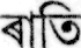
ৰাতি
